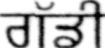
ਗੱਡੀ
